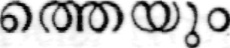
ത്തെയും
